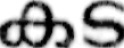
കട
